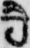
ਹੈ
